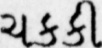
ચકકી
